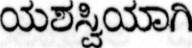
ಯಶಸ್ವಿಯಾಗಿ
